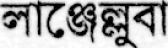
লাঞ্জেল্লুবা
